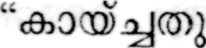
“കായ്ച്ചതു
